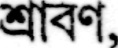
শ্রাবণ,
